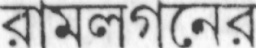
রামলগনের
